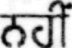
ਨਹੀਂ
